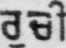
ਰੁਚੀ
